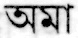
অমা
